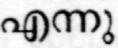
എന്നു
